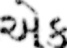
એક
